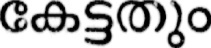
കേട്ടതും
